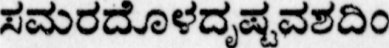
ಸಮರದೊಳದೃಷ್ಟವಶದಿಂ
